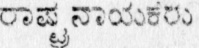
ರಾಷ್ಟ್ರನಾಯಕರು
